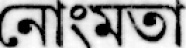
নোংমতা
